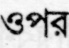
ওপর
